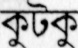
কুটকু
